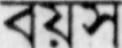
বয়স
